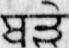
ਬੜੇ
